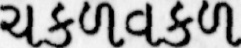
ચકળવકળ
